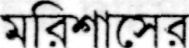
মরিশাসের
